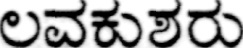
ಲವಕುಶರು
